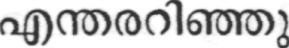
എന്തരറിഞ്ഞു
